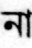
না
